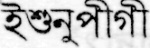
ইশুনুপীগী
